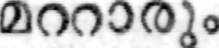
മററാരും
